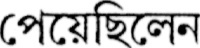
পেয়েছিলেন
